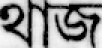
থাজ
